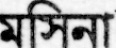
মসিনা
